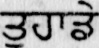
ਤੁਹਾਡੇ
